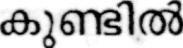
കുണ്ടില്‍
